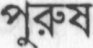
পুরুষ
